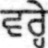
ਵਰ੍ਹੇ
